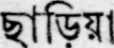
ছাড়িয়া
